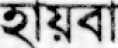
হায়বা
